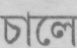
চালে
